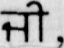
ਜੀ,
